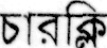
চারক্লি
